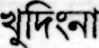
খুদিংনা
